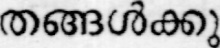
തങ്ങള്‍ക്കു
